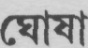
ঘোষা
